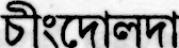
চীংদোলদা
